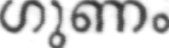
ഗുണം
